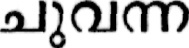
ചുവന്ന
